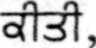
ਕੀਤੀ,
